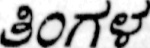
ತಿಂಗಳ
